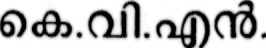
കെ.വി.എന്‍.
